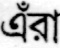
এঁরা
